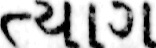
ત્યાગ
